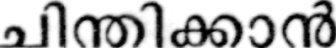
ചിന്തിക്കാന്‍
